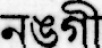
নঙগী
